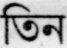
তিন
